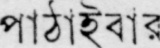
পাঠাইবার
